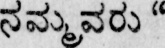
ನಮ್ಮವರು”
